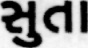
સુતા
